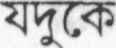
যদুকে
